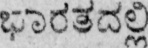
ಭಾರತದಲ್ಲಿ
